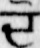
ਦੋ
